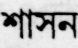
শাসন
